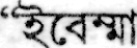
“ইবেম্মা
